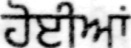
ਹੋਈਆਂ
